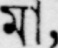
মা,
